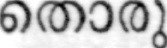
തൊരു
